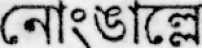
নোংঙাল্লে
